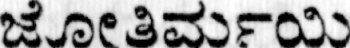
ಜೋತಿರ್ಮಯಿ
